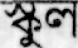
স্কুল
